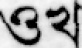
ওখ
